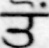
ਤੋਂ
